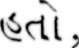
હતો,
